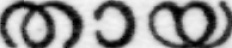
തായ
